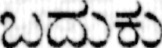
ಬದುಕು
